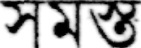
সমস্ত
